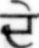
ਦੇ
